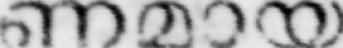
ണമായ
